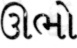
ઊભો
